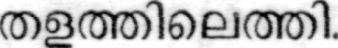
തളത്തിലെത്തി.
